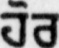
ਹੋਰ
